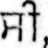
ਸੀ,
